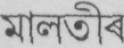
মালতীৰ
